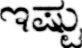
ಇಷ್ಟು
